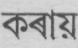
কৰায়
